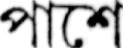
পাশে
